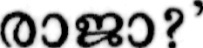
രാജാ?’
